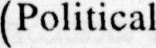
(Political
